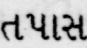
તપાસ
